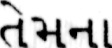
તેમના
